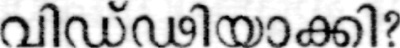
വിഡ്ഢിയാക്കി?
